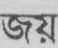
জয়
